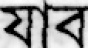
যাব
